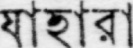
যাহারা
